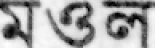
মওল
